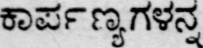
ಕಾರ್ಪಣ್ಯಗಳನ್ನ
